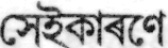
সেইকাৰণে
